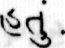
હતું.
